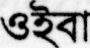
ওইবা
